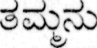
ತಮ್ಮನು
